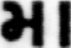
મા
